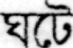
ঘটে
